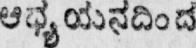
ಆಧ್ಯಯನದಿಂದ
